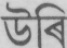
উৰি
